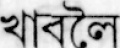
খাবলৈ
